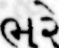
ભરે
